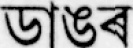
ডাঙৰ
